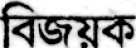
বিজয়ক
